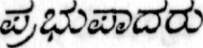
ಪ್ರಭುಪಾದರು
